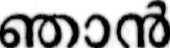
ഞാന്‍
